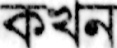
কখন
